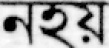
নহয়
